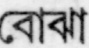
বোঝা
